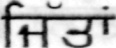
ਜਿੱਤਾਂ
